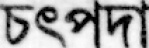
চৎপদা
